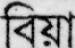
বিয়া
